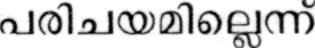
പരിചയമില്ലെന്ന്
